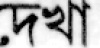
দেখা
